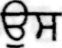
ਉਸ
